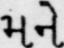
મને
